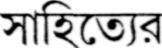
সাহিত্যের
